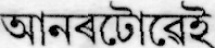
আনৰটোৱেই
